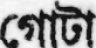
গোটা
